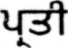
ਪ੍ਰਤੀ
